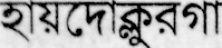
হায়দোক্লুরগা
